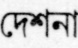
দেশনা
